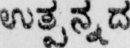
ಉತ್ಪನ್ನದ
